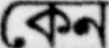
কেন
